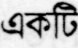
একটি
